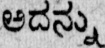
ಅದನ್ನು
